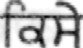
ਕਿਸੇ
